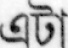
এটা
